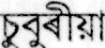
চুবুৰীয়া
